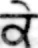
ਕੇ
